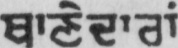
ਥਾਣੇਦਾਰਾਂ
